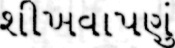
શીખવાપણું
